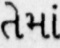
તેમાં
